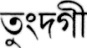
তুংদগী
